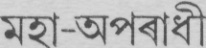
মহা-অপৰাধী
